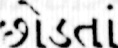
છોડતાં
